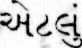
એટલું
